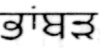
ਭਾਂਬੜ
